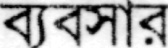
ব্যবসার
